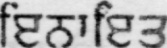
ਇਨਾਇਤ
